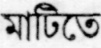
মাটিতে
